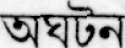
অঘটন
